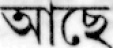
আছে
